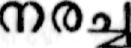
നരച്ച
